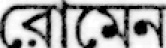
রোমেন
